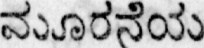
ಮೂರನೆಯ
